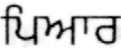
ਪਿਆਰ
